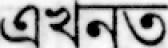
এখনত
